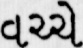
વચ્ચે
